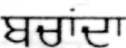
ਬਚਾਂਦਾ
